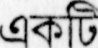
একটি
